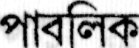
পাবলিক
